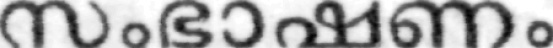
സംഭാഷണം
